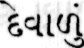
દેવાળું
